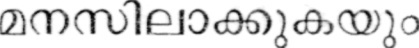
മനസിലാക്കുകയും
